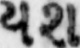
યશ
